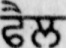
ਫੈਲ
